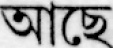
আছে
